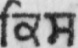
ਕਿਸ
